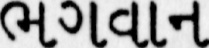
ભગવાન
